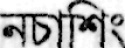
নচাশিং
